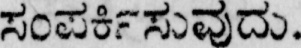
ಸಂಪರ್ಕಿಸುವುದು.
